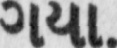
ગયા.
